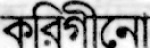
করিগীনো
